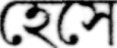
হেসে
